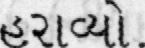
હરાવ્યો.
